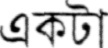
একটা
